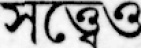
সত্ত্বেও
